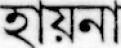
হায়না
